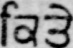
ਕਿਤੇ
